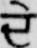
ਦੇ
